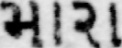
મારા
